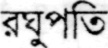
রঘুপতি
